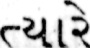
ત્યારે
